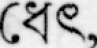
ধেৎ,
